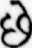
છે
